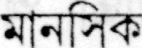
মানসিক
